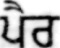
ਪੈਰ
